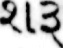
શરૂ
